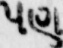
પણ
